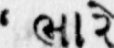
'ભારે
